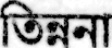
তিন্ননা
